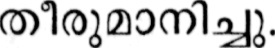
തീരുമാനിച്ചു.
